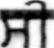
ਸੀ
